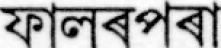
ফালৰপৰা
